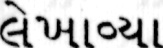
લેખાવ્યા
